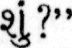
શું?"
